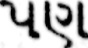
પણ
